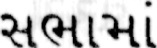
સભામાં
